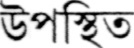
উপস্থিত
